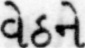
વેઠને
